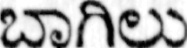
ಬಾಗಿಲು
